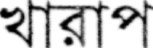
খারাপ
